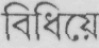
বিধিয়ে
